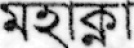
মহাক্না
